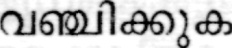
വഞ്ചിക്കുക
